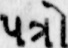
પત્રો
